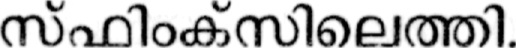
സ്ഫിംക്സിലെത്തി.
